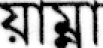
য়াম্না
